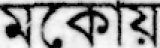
মকোয়
